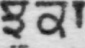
ਝੁਕਾ
